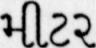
મીટર
